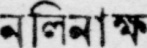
নলিনাক্ষ
